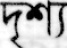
দৃশ্য
